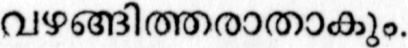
വഴങ്ങിത്തരാതാകും.
